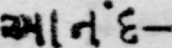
આનંદ
